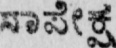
ಸಾಪೇಕ್ಷ
